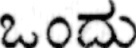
ಒಂದು
